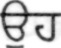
ਉਹ
